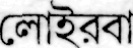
লোইরবা
